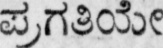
ಪ್ರಗತಿಯೇ
